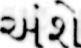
અંશે
